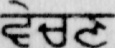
ਵੇਚਣ
